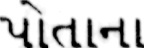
પોતાના
